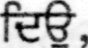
ਦਿਉ,
